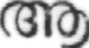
ആ
